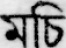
মচি
